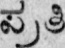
ಪ್ರತಿ
